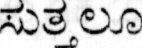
ಸುತ್ತಲೂ
